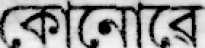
কোনোৱে
